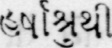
હર્ષાશ્રુથી
